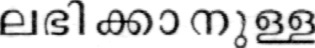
ലഭിക്കാനുള്ള
